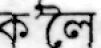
ক'লৈ
